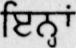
ਇਨ੍ਹਾਂ
